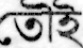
তৌই
